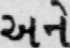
અને
